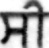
ਸੀ
